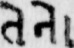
તેનો
